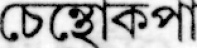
চেন্থোকপা
